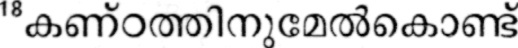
18കണ്ഠത്തിനുമേല്‍കൊണ്ട്
